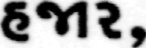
હજાર,
